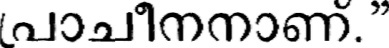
പ്രാചീനനാണ്."
